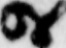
જ
